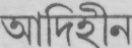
আদিহীন
